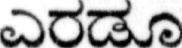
ಎರಡೂ
